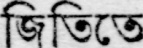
জিতিতে
